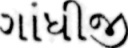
ગાંધીજી
